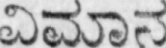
ವಿಮಾನ
